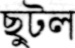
ছুটল
